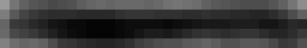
મેરે
